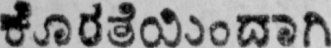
ಕೊರತೆಯಿಂದಾಗಿ
